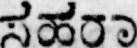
ಸಹರಾ
